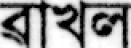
ৱাখল
